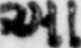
આ
